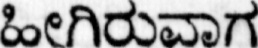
ಹೀಗಿರುವಾಗ
